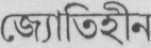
জ্যোতিহীন
